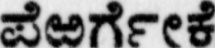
ಪೆಱರ್ಗೇಕೆ
